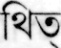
থিত্
